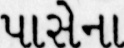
પાસેના
